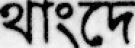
থাংদে
